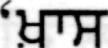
'ਖ਼ਾਸ
